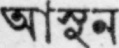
আসুন
